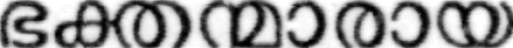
ഭക്തന്മാരായ
